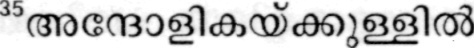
35അന്ദോളികയ്ക്കുള്ളില്‍
